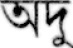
অদু
